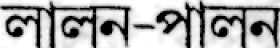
লালন-পালন
